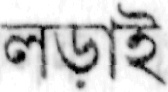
লড়াই
